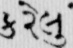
કરેલું
